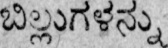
ಬಿಲ್ಲುಗಳನ್ನು
